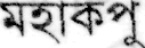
মহাকপু
